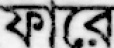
ফারে
